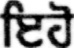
ਇਹੋ
